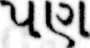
પણ
